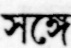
সঙ্গে
